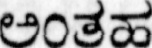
ಅಂತಹ
